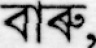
বাৰু,
